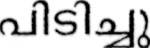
പിടിച്ചു
